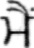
ਮੈਂ
